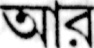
আর
